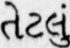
તેટલું
